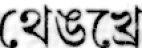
থেঙখ্রে
